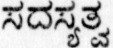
ಸದಸ್ಯತ್ವ
